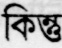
কিন্তু
